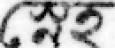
স্নেহ
